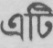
এটি
